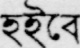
হইবে
